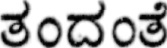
ತಂದಂತೆ
